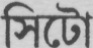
সিটো
